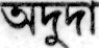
অদুদা
